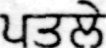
ਪਤਲੇ
